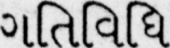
ગતિવિધિ
